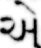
એ
